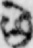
છે
